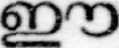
ഈ
